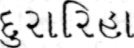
દુરારિહા
